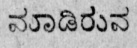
ಮಾಡಿರುವ
